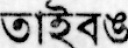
তাইবঙ
